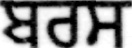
ਬਰਸ
